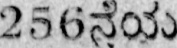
256ನೆಯ
